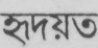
হৃদয়ত
